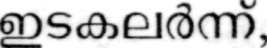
ഇടകലര്‍ന്ന്,
